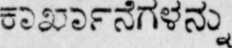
ಕಾರ್ಖಾನೆಗಳನ್ನು
